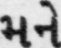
મને
